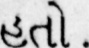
હતો.
